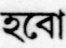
হবো
